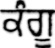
ਕੰਗੂ
